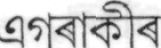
এগৰাকীৰ
